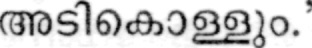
അടികൊള്ളും.’
